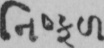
નિષ્ફળ
